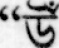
"উঁ
